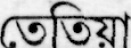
তেতিয়া
